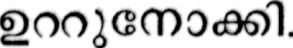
ഉററുനോക്കി.
